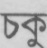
চকু
